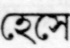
হেসে
